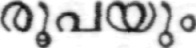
രൂപയും
